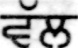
ਵੱਲ
